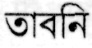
তাবনি
